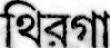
থিরগা
